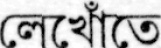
লেখোঁতে
